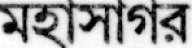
মহাসাগর
